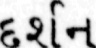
દર્શન
